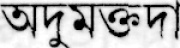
অদুমক্তদা
